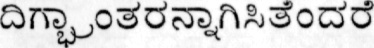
ದಿಗ್ಭ್ರಾಂತರನ್ನಾಗಿಸಿತೆಂದರೆ
